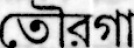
তৌরগা
